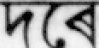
দৰে
